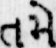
તમે
